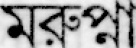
মরুপ্না
